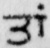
ਤਾਂ
